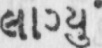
લાગ્યું
